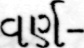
વર્ણ
